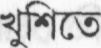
খুশিতে
